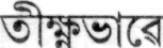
তীক্ষ্ণভাৱে
